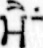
ਮੈਂ
